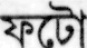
ফটো
